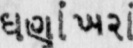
ઘણાંખરાં
